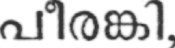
പീരങ്കി,
